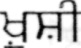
ਖ਼ੁਸ਼ੀ
